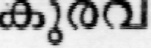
കുരവ
